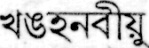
খঙহনবীয়ু
